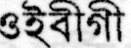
ওইবীগী
